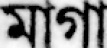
মাগা
